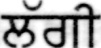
ਲੱਗੀ
